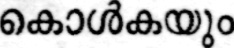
കൊള്‍കയും
